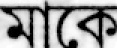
মাকে
